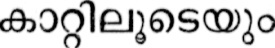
കാറ്റിലൂടെയും
